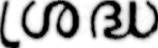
ശ്രദ്ധ
